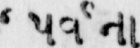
'પર્વના
